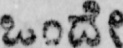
ಒಂದೇ
